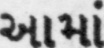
આમાં
